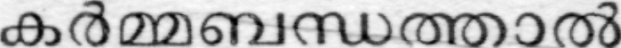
കര്‍മ്മബന്ധത്താല്‍
